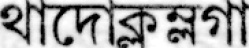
থাদোক্লম্লগা
